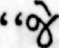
"જે
